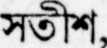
সতীশ,
